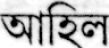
আহিল
